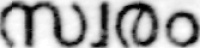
സ്വരം
